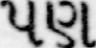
પણ
